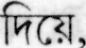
দিয়ে,
